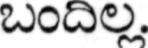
ಬಂದಿಲ್ಲ.
